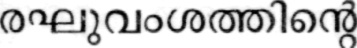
രഘുവംശത്തിന്റെ
